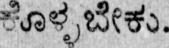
ಕೊಳ್ಳಬೇಕು.
